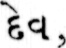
દેવ,
